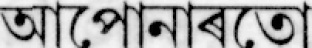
আপোনাৰতো
